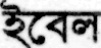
ইবেল
